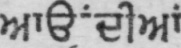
ਆਉਂਦੀਆਂ
